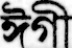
ঈগী
